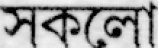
সকলো
